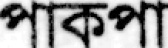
পাকপা
